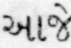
આજે
